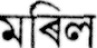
মৰিল
